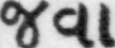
જવા
